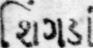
શિંગડાં
